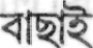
বাছাই
